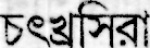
চৎখ্রসিরা
